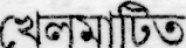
খেলমাটিত
